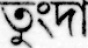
তুংদা
